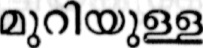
മുറിയുള്ള
